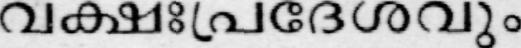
വക്ഷഃപ്രദേശവും
